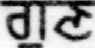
ਗੁਣ
